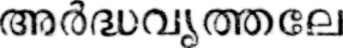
അര്‍ദ്ധവൃത്തലേ
